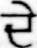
ਦੇ
